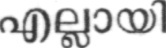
എല്ലായി
